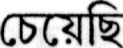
চেয়েছি
